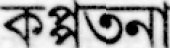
কপ্পতনা
